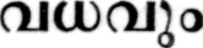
വധവും
